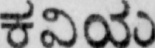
ಕವಿಯ
